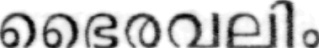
ഭൈരവലിം
